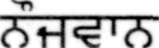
ਨੌਜਵਾਨ
